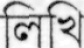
লিখি
